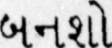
બનશો
